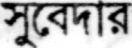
সুবেদার
